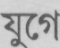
যুগে
